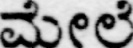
ಮೇಲೆ
